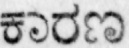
ಕಾರಣ
